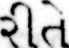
રીતે
